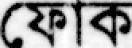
ফোক
